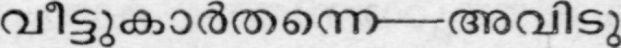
വീട്ടുകാര്‍തന്നെ-അവിടു
